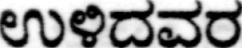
ಉಳಿದವರ
